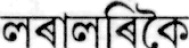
লৰালৰিকৈ
